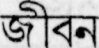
জীবন
